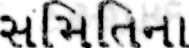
સમિતિના
